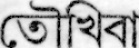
তৌখিবা
